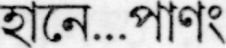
হানে...পাণং
